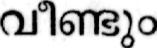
വീണ്ടും
